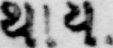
થાય.
